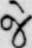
જે
